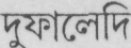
দুফালেদি
